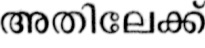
അതിലേക്ക്
